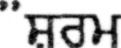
''ਸ਼ਰਮ
